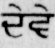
ਦੇਵੇ
